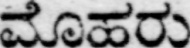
ಮೊಹರು
